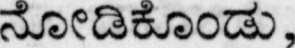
ನೋಡಿಕೊಂಡು,
